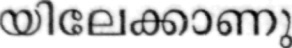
യിലേക്കാണു
